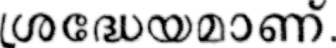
ശ്രദ്ധേയമാണ്.
